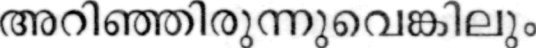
അറിഞ്ഞിരുന്നുവെങ്കിലും
